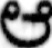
ಆ
